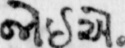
જોઈએ.
